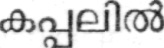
കപ്പലില്‍
